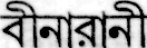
বীনারানী
